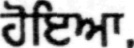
ਹੋਇਆ,
